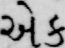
એક
